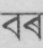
বৰ
